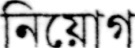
নিয়োগ
